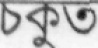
চকুত
